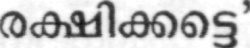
രക്ഷിക്കട്ടെ’
